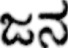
ಜನ
